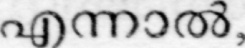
എന്നാല്‍,
